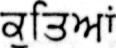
ਕੁਤਿਆਂ
